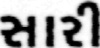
સારી
